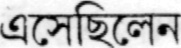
এসেছিলেন
